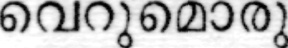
വെറുമൊരു
